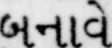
બનાવે
